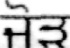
ਜੋੜ
